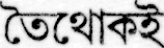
তৈথোকই
